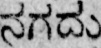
ನಗದು
